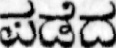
ಪಡೆದ
